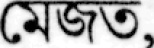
মেজত,
